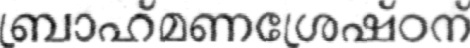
ബ്രാഹ്മണശ്രേഷ്ഠന്
